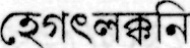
হেগৎলক্কনি
